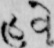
હવે
